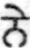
ਨੇ
